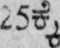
25ಕ್ಕೆ
